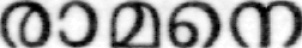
രാമനെ
